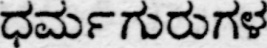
ಧರ್ಮಗುರುಗಳ
